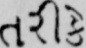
તરીકે
